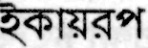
ইকায়রপ
